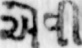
એવી
